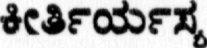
ಕೀರ್ತಿರ್ಯಸ್ಯ
